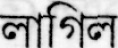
লাগিল
